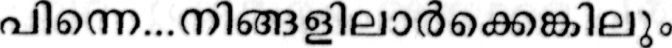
പിന്നെ...നിങ്ങളിലാര്‍ക്കെങ്കിലും
